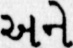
અને
